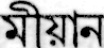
মীয়ান
